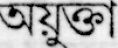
অয়ুক্তা
